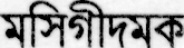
মসিগীদমক
